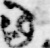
છે.
